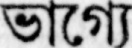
ভাগ্যে
